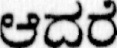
ಆದರೆ
